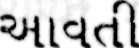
આવતી
